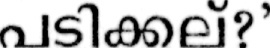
പടിക്കല്?’
